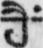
ਹੈਂ
